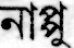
নাপ্পু
